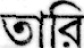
তারি
